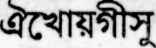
ঐখোয়গীসু
